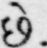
છે.
